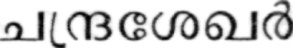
ചന്ദ്രശേഖര്‍
